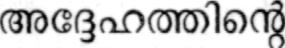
അദ്ദേഹത്തിന്റെ
